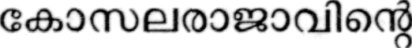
കോസലരാജാവിന്റെ
